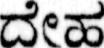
ದೇಹ
